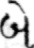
બે
